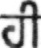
ਹੀ
